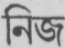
নিজ
